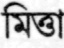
মিত্তা
